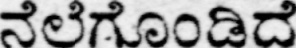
ನೆಲೆಗೊಂಡಿದೆ
